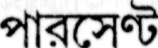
পারসেন্ট
